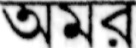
অমর
